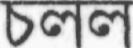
চলল
